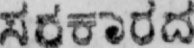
ಸರಕಾರದ
